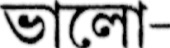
ভালো-
